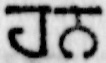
ਹਨ
